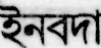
ইনবদা
